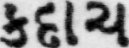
કદાચ
